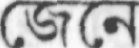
জেনে
